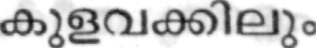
കുളവക്കിലും
